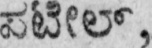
ಪಟೇಲ್,
